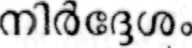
നിര്‍ദ്ദേശം
